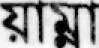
য়াম্না
